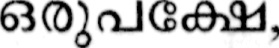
ഒരുപക്ഷേ,
